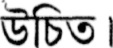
উচিত।
